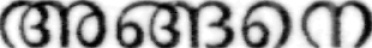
അങ്ങനെ
